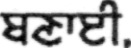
ਬਣਾਈ,
